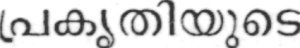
പ്രകൃതിയുടെ
